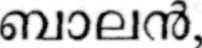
ബാലന്‍,
